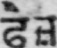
ਫੈਜ਼
